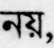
নয়,
